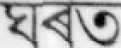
ঘৰত
